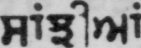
ਸਾਂਝੀਆਂ
